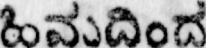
ಹಿಮದಿಂದ
